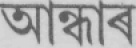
আন্ধাৰ
